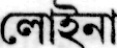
লোইনা
